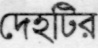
দেহটির
